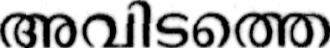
അവിടത്തെ
